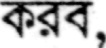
করব,
